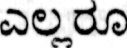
ಎಲ್ಲರೂ
